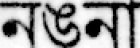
নঙনা
